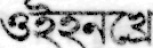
ওইহনখ্রে
